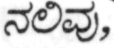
ನಲಿವು,
